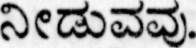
ನೀಡುವವು.
